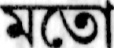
মতো
